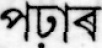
পঢ়াৰ
